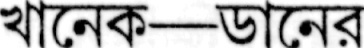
খানেক–ডানের
